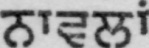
ਨਾਵਲਾਂ
